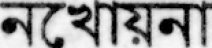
নখোয়না
